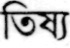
তিষ্য
